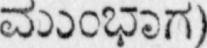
ಮುಂಭಾಗ)
